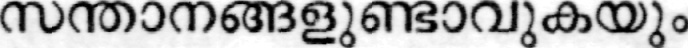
സന്താനങ്ങളുണ്ടാവുകയും
